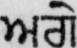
ਅਗੇ
